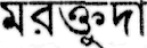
মরক্তুদা
